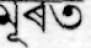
মূৰত
